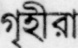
গৃহীরা
